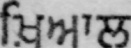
ਖ਼ਿਆਲ
